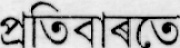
প্রতিবাৰতে
